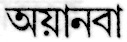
অয়ানবা
